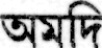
অমদি
